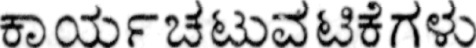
ಕಾರ್ಯಚಟುವಟಿಕೆಗಳು
